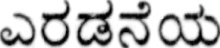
ಎರಡನೆಯ
